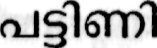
പട്ടിണി
